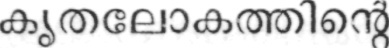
കൃതലോകത്തിന്റെ
